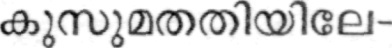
കുസുമതതിയിലേ-
